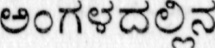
ಅಂಗಳದಲ್ಲಿನ
